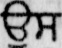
ਉਸ
